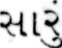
સારું
